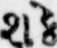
શકે
